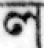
ল
